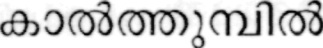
കാല്‍ത്തുമ്പില്‍
